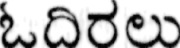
ಓದಿರಲು
